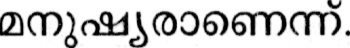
മനുഷ്യരാണെന്ന്.
